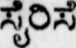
ಸೈರಿಸೆ
